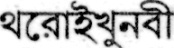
থরোইখুনবী
